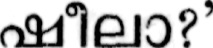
ഷീലാ?’
